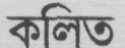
কলিত
